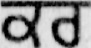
ਕਰ
